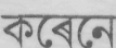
কৰেনে
